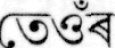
তেওঁৰ
